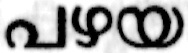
പഴയ
